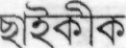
ছাইকীক
